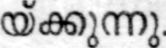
യ്ക്കുന്നു.
